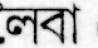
লৈবা
